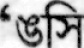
‘ঙসি
